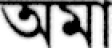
অমা
